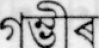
গম্ভীৰ
